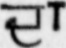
ਦਾ
